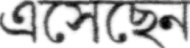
এসেছেন
